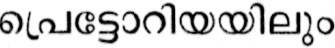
പ്രെട്ടോറിയയിലും
